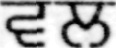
ਵਲ
